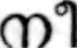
നീ
